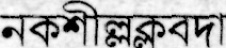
নকশীল্লক্লবদা
